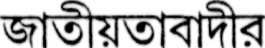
জাতীয়তাবাদীর
